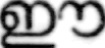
ഈ
